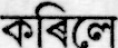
কৰিলে
